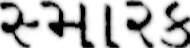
સ્મારક
